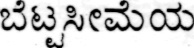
ಬೆಟ್ಟಸೀಮೆಯ
